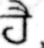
ਹੈ,
